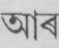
আৰ
